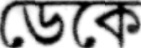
ডেকে
